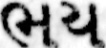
ભય
